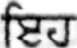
ਇਹ
